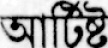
আর্টিষ্ট
